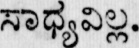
ಸಾಧ್ಯವಿಲ್ಲ.
